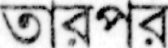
তারপর
